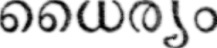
ധൈര്യം
